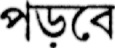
পড়বে
